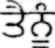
ਤੈਨੂੰ
